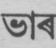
ভাৰ
